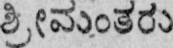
ಶ್ರೀಮಂತರು
